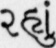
રહ્યું
